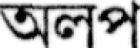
অলপ
